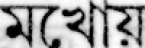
মখোয়
